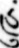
હું
